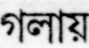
গলায়
